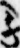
કે
